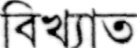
বিখ্যাত
